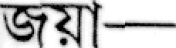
জয়া-
